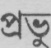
প্ৰভু
